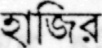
হাজির
